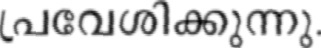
പ്രവേശിക്കുന്നു.
